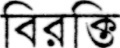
বিরক্তি
